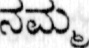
ನಮ್ಮ
